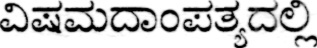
ವಿಷಮದಾಂಪತ್ಯದಲ್ಲಿ
